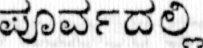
ಪೂರ್ವದಲ್ಲಿ
